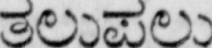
ತಲುಪಲು
